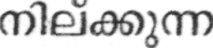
നില്ക്കുന്ന
